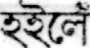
হইলে
